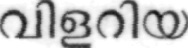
വിളറിയ
